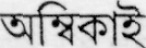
অম্বিকাই
